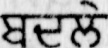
ਬਦਲੇ
